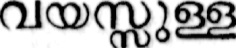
വയസ്സുള്ള
